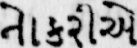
નોકરીએ
